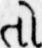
તો
